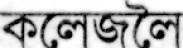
কলেজলৈ
